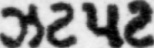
ઝટપટ
